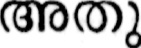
അതു
